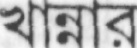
খান্নার
